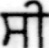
ਸੀ
